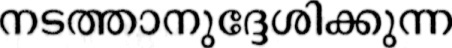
നടത്താനുദ്ദേശിക്കുന്ന
